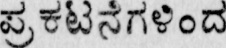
ಪ್ರಕಟನೆಗಳಿಂದ
